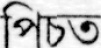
পিচত
